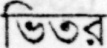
ভিতর
